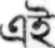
এই
